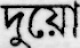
দুয়ো
